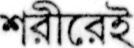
শরীরেই
